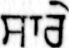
ਸਾਰੇ
